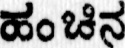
ಹಂಚಿನ
